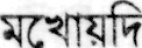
মখোয়দি
